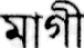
মাগী
